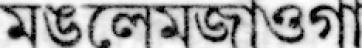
মঙলেমজাওগা
